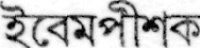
ইবেমপীশক
